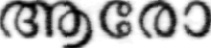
ആരോ
